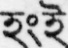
হংই
